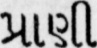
પ્રાણી
